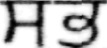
ਸਭ
